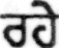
ਰਹੇ
